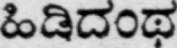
ಹಿಡಿದಂಥ
